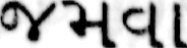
જમવા
